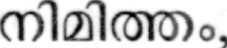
നിമിത്തം,
